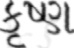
કૃષ્ણ
